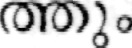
ത്തും
